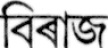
বিৰাজ
